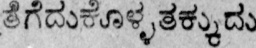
ತೆಗೆದುಕೊಳ್ಳತಕ್ಕುದು
